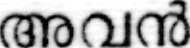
അവന്‍
